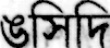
ঙসিদি
